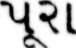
પૂરા
